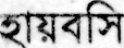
হায়বসি
